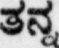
ತನ್ನ
